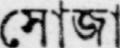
সোজা
